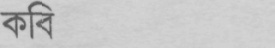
কবি
